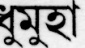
ধুমুহা
